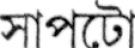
সাপটো
